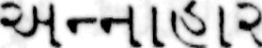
અન્નાહાર
